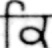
ਕਿ
